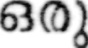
ഒരു
